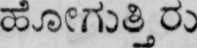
ಹೋಗುತ್ತಿರು
